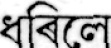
ধৰিলে
